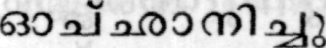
ഓച്ഛാനിച്ചു
